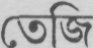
তেজি
